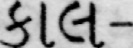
કાલ-
